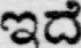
ಇದೆ
